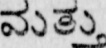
ಮತ್ತು
